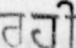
ਰਹੀ
